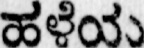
ಹಳೆಯ
